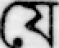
যে
